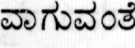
ವಾಗುವಂತೆ
